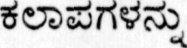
ಕಲಾಪಗಳನ್ನು
